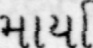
માર્યા
